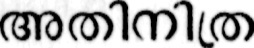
അതിനിത്ര
